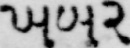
ખબર
